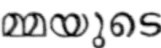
മ്മയുടെ
